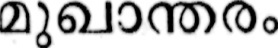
മുഖാന്തരം
